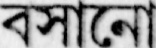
বসানো
